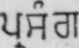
ਪ੍ਰਸੰਗ
